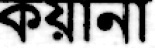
কয়ানা
